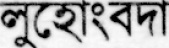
লুহোংবদা
